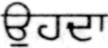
ਉਹਦਾ
